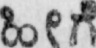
ಹೀಗೆ
